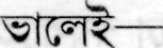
ভালেই-
